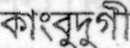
কাংবুদুগী
